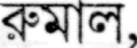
রুমাল,
